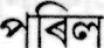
পৰিল
